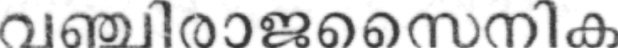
വഞ്ചിരാജസൈനിക
